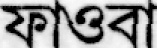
ফাওবা
